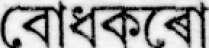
বোধকৰো
